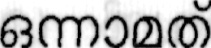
ഒന്നാമത്
